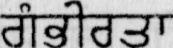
ਗੰਭੀਰਤਾ
